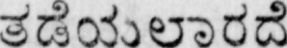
ತಡೆಯಲಾರದೆ
